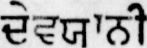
ਦੇਵਯਾਨੀ
